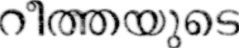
റീത്തയുടെ
